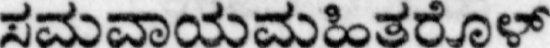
ಸಮವಾಯಮಹಿತರೊಳ್
